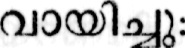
വായിച്ചു:
